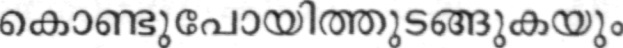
കൊണ്ടുപോയിത്തുടങ്ങുകയും
